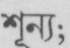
শূন্য;
